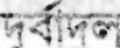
দুৰ্বাদল
